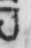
ਹੋ
